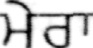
ਮੇਰਾ
